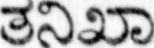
ತನಿಖಾ
